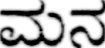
ಮನ
